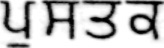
ਪੁਸਤਕ
